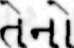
તેનો
